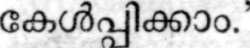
കേള്‍പ്പിക്കാം.’
